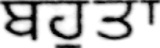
ਬਹੁਤਾ
